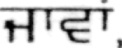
ਜਾਵਾਂ,
